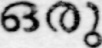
ഒരു
